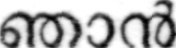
ഞാന്‍
